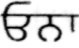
ਓਨਾ
